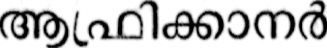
ആഫ്രിക്കാനര്‍
